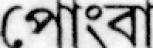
পোংবা
